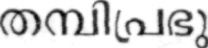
തമ്പിപ്രഭു
